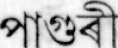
পাগুৰী
